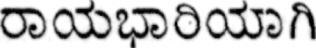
ರಾಯಭಾರಿಯಾಗಿ
